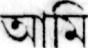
আমি
